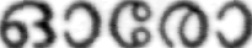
ഓരോ
